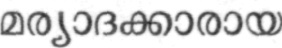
മര്യാദക്കാരായ
